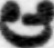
ಆ
